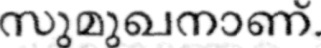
സുമുഖനാണ്.
